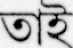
তাই
